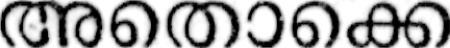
അതൊക്കെ
